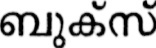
ബുക്സ്
